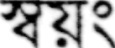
স্বয়ং
